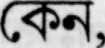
কেন,
